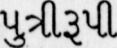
પુત્રીરૂપી
